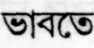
ভাবতে
